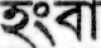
হংবা
